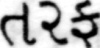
તરફ
